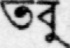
তবু
